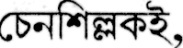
চেনশিল্লকই,
